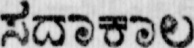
ಸದಾಕಾಲ
